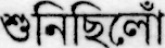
শুনিছিলোঁ
